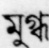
মুগ্ধ
